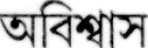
অবিশ্বাস
